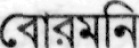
বোরমনি
